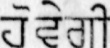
ਹੋਵੇਗੀ
